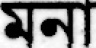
মনা
